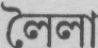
লৈলা
